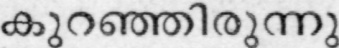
കുറഞ്ഞിരുന്നു
